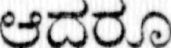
ಆದರೂ
